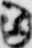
છે
